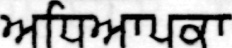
ਅਧਿਆਪਕਾ
